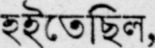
হইতেছিল,
